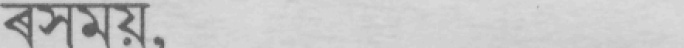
ৰসময়,
